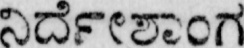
ನಿರ್ದೇಶಾಂಗ
